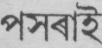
পসৰাই
